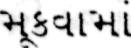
મૂકવામાં
